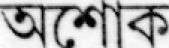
অশোক
